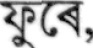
ফুৰে,
